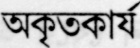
অকৃতকার্য
